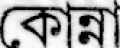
কোন্না
